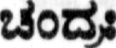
ಚಂದ್ರಃ
